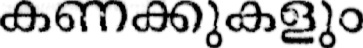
കണക്കുകളും
